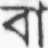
বা
